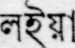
লইয়া
